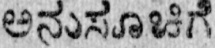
ಅನುಸೂಚಿಗೆ
